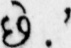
છે.'
